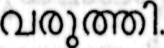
വരുത്തി.
